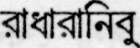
রাধারানিবু
